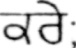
ਕਰੇ;
